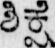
ಶಿಕ್ಷೆ
